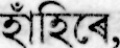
হাঁহিৰে,
